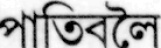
পাতিবলৈ
